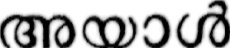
അയാള്‍
